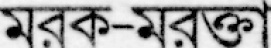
মরক-মরক্তা
